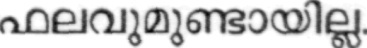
ഫലവുമുണ്ടായില്ല.
